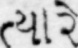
ત્યારે
